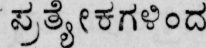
ಪ್ರತ್ಯೇಕಗಳಿಂದ
